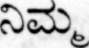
ನಿಮ್ಮ
